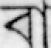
বা
